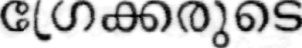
ഗ്രേക്കരുടെ
